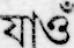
যাওঁ
